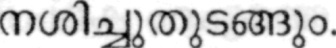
നശിച്ചുതുടങ്ങും.
